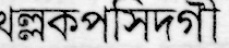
খল্লকপসিদগী
